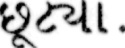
છૂટ્યા.
